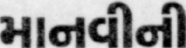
માનવીની
